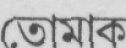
তোমাক
